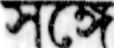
সঙ্গে
